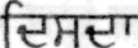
ਦਿਸਦਾ
